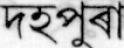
দহপুৰা
